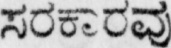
ಸರಕಾರವು
